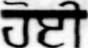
ਹੋਈ
